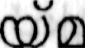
യ്മ
